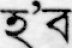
হ'ব
